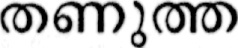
തണുത്ത
